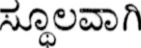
ಸ್ಥೂಲವಾಗಿ
